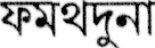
ফমথদুনা
